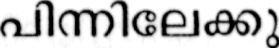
പിന്നിലേക്കു
